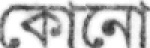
কোনো
